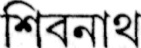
শিবনাথ
